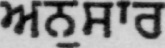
ਅਨੁਸਾਰ
